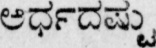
ಅರ್ಧದಷ್ಟು
